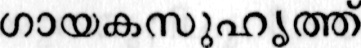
ഗായകസുഹൃത്ത്
